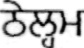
ਠੇਲ੍ਹਮ
